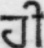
ਹੀ
